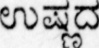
ಉಷ್ಣದ
